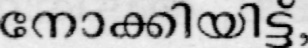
നോക്കിയിട്ട്,
